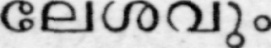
ലേശവും
